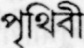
পৃথিবী
